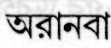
অরানবা
